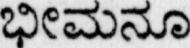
ಭೀಮನೂ
